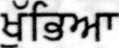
ਖੁੱਭਿਆ
